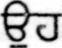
ਉਹ
